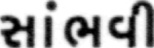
સાંભવી
